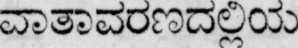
ವಾತಾವರಣದಲ್ಲಿಯ
